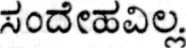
ಸಂದೇಹವಿಲ್ಲ.
